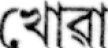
খোৱা
